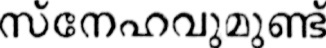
സ്നേഹവുമുണ്ട്
